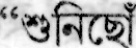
"শুনিছোঁ
